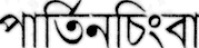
পার্তিনচিনবা
